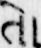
તો
